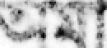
অমা
